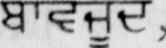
ਬਾਵਜੂਦ,
